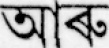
আৰু
